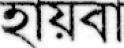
হায়বা
